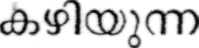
കഴിയുന്ന
